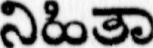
ನಿಹಿತಾ
